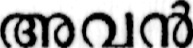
അവന്‍
